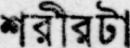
শরীরটা
